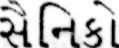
સૈનિકો
